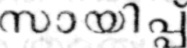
സായിപ്പ്
